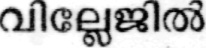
വില്ലേജില്‍
